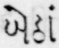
બેઠાં
